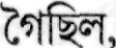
গৈছিল,
